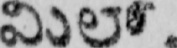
ಮಿಲ್.
